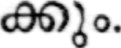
ക്കും.
